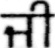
ਜੀ
